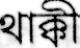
থাক্কী
